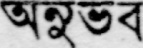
অনুভব
